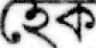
হেক
